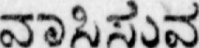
ವಾಸಿಸುವ
